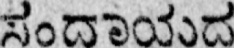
ಸಂದಾಯದ
